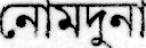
নোমদুনা
